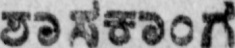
ಶಾಸಕಾಂಗ
